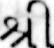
શ્રી
